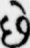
છે
